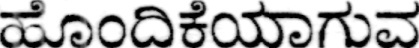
ಹೊಂದಿಕೆಯಾಗುವ
